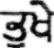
ਭੁਖੇ
